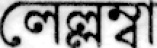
লেল্লম্বা
